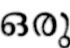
ഒരു
